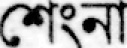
শেংনা
